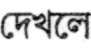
দেখলে
